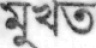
মুখত
